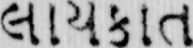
લાયકાત
